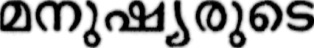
മനുഷ്യരുടെ
